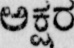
ಅಕ್ಷರ
